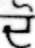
ਦੋ
